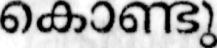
കൊണ്ടു
